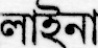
লাইনা
